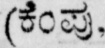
(ಕೆಂಪು,
